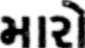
મારો
